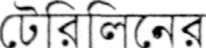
টেরিলিনের
